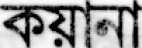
কয়ানা
